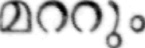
മററും
